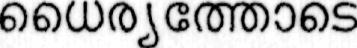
ധൈര്യത്തോടെ
